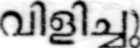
വിളിച്ചു
